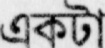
একটা
